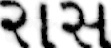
રાસ
